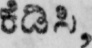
ಕೆಡಿಸಿ,
